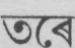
তৰে
